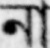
না
